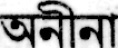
অনীনা
